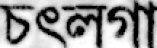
চৎলগা
